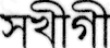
সখীগী
